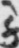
કે
